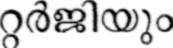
റ്റര്‍ജിയും
